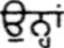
ਉਨ੍ਹਾਂ
